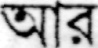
আর
